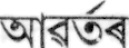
আৱর্তৰ
